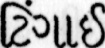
ટિંગાઈ
